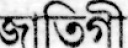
জাতিগী
